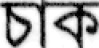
চাক
